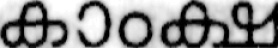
കാംക്ഷ
